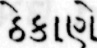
ઠેકાણે
